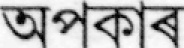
অপকাৰ
